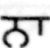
ਨਾ
